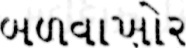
બળવાખોર
